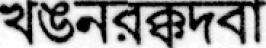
খঙনরক্কদবা
